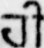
ਹੀ
